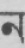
ন
